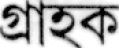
গ্রাহক
